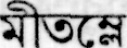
মীতম্লে
